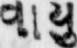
વાયુ
